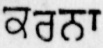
ਕਰਨਾ
